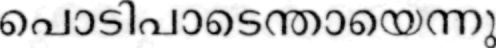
പൊടിപാടെന്തായെന്നു
